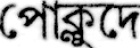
পোক্লুদে
